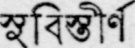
সুবিস্তীর্ণ
